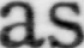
as
